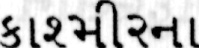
કાશ્મીરના
